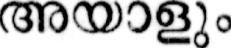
അയാളും
